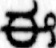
ಈ
